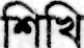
শিখি
